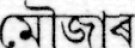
মৌজাৰ
